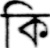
কি
